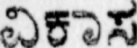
ವಿಕಾಸ
